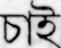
চাই
